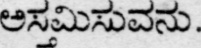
ಅಸ್ತಮಿಸುವನು.
